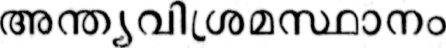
അന്ത്യവിശ്രമസ്ഥാനം
